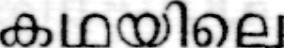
കഥയിലെ
